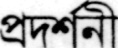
প্রদর্শনী
